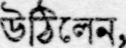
উঠিলেন,
